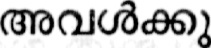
അവള്‍ക്കു
